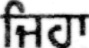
ਜਿਹਾ
